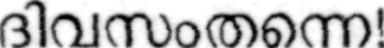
ദിവസംതന്നെ!
